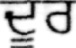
ਦੂਰ
